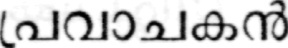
പ്രവാചകന്‍
